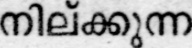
നില്ക്കുന്ന
